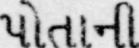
પોતાની
